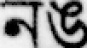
নঙ
